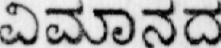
ವಿಮಾನದ
